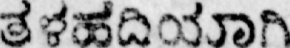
ತಳಹದಿಯಾಗಿ
